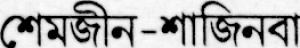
শেমজীন-শাজিনবা
